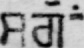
ਸਗੋਂ
